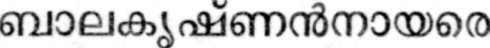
ബാലകൃഷ്ണന്‍നായരെ
